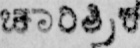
ಚಾರಿತ್ರಿಕ
